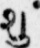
શું
